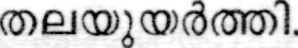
തലയുയര്‍ത്തി.
